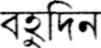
বহুদিন
